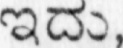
ಇದು,
